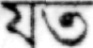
যত
